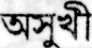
অসুখী
